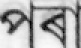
পৰা
